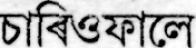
চাৰিওফালে
